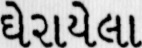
ઘેરાયેલા
